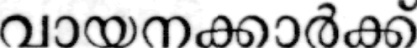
വായനക്കാര്‍ക്ക്
